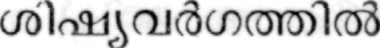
ശിഷ്യവര്‍ഗത്തില്‍
